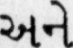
અને
